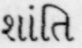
શાંતિ
